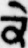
ਕੇ
